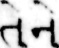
તેને
